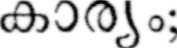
കാര്യം;
